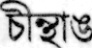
চীন্থাঙ
